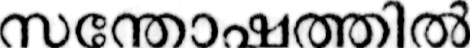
സന്തോഷത്തില്‍
